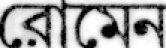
রোমেন
